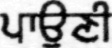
ਪਾਉਣੀ
